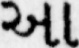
આ
